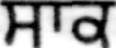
ਸਾਕ
